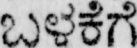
ಬಳಕೆಗೆ
